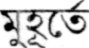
মুহূর্তে
